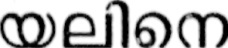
യലിനെ
